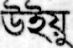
উইয়ু
